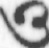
ও
